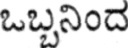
ಒಬ್ಬನಿಂದ
